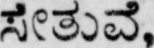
ಸೇತುವೆ,
